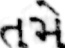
તમે
